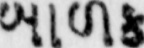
બાળક
